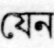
যেন
